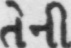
તેની
